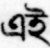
এই
